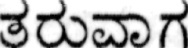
ತರುವಾಗ
